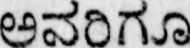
ಅವರಿಗೂ
